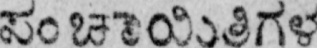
ಪಂಚಾಯಿತಿಗಳ
